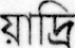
য়াদ্রি
